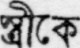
স্ত্রীকে
